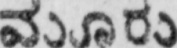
ಮೂರು
